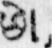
છો,
